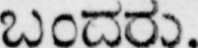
ಬಂದರು.
